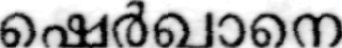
ഷെര്‍ഖാനെ
